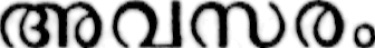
അവസരം
